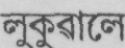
লুকুৱালে
